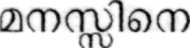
മനസ്സിനെ
